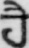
ਹੈ
